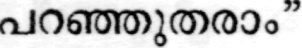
പറഞ്ഞുതരാം”
